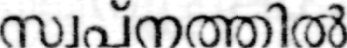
സ്വപ്നത്തില്‍
